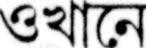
ওখানে
